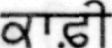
ਕਾਫ਼ੀ
